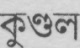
কুণ্ডল
